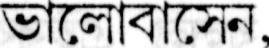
ভালোবাসেন,
